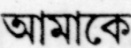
আমাকে
